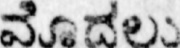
ಮೊದಲು
